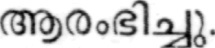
ആരംഭിച്ചു.
